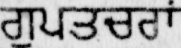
ਗੁਪਤਚਰਾਂ
